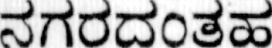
ನಗರದಂತಹ
